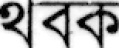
থবক
